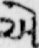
એ
